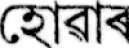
হোৱাৰ
